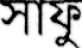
সাফু
